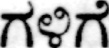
ಗಳಿಗೆ
